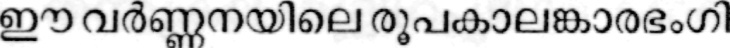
ഈവര്‍ണ്ണനയിലെരൂപകാലങ്കാരഭംഗി
